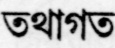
তথাগত
